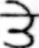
ਤੇ
